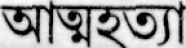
আত্মহত্যা
